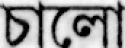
চালো
